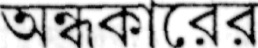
অন্ধকারের
